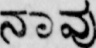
ನಾವು
